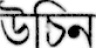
উচিন
